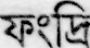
ফংদ্রি
